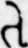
તે
